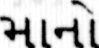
માનો
